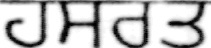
ਹਸਰਤ
